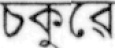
চকুৱে
